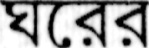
ঘরের
